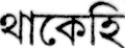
থাকেহি
